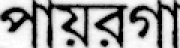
পায়রগা
